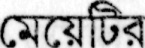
মেয়েটির
